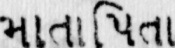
માતાપિતા
